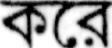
করে
